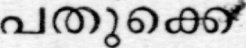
പതുക്കെ
